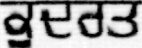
ਕੁਦਰਤ
